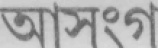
আসংগ
